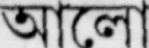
আলো
